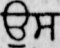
ਉਸ
